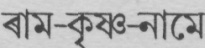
ৰাম-কৃষ্ণ-নামে
